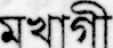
মখাগী
